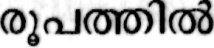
രൂപത്തില്‍
